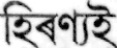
হিৰণ্যই
